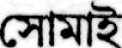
সোমাই
